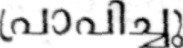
പ്രാപിച്ചു
